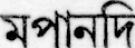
মপানদি
